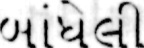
બાંધેલી
